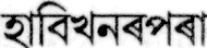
হাবিখনৰপৰা
